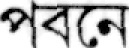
পবনে
